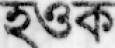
হওক
